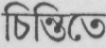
চিন্তিতে
